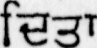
ਦਿਤਾ
